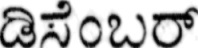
ಡಿಸೆಂಬರ್
